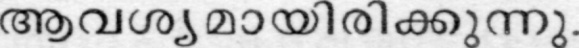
ആവശ്യമായിരിക്കുന്നു.
